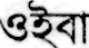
ওইবা
